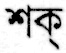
শক্
